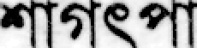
শাগৎপা
